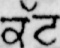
ਕੱਟ
